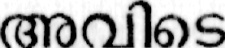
അവിടെ
